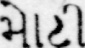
મોટી
